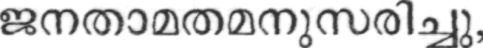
ജനതാമതമനുസരിച്ചു,
